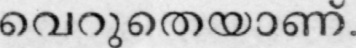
വെറുതെയാണ്.
